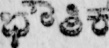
ಭೌತಿಕ
